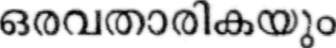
ഒരവതാരികയും
